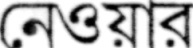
নেওয়ার
